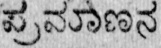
ಪ್ರಮಾಣನ
